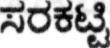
ಸರಕಟ್ಟಿ
